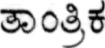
ತಾಂತ್ರಿಕ
